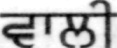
ਵਾਲੀ
